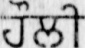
ਹੌਲੀ
